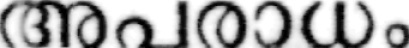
അപരാധം
